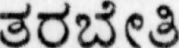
ತರಬೇತಿ
